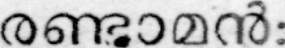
രണ്ടാമന്‍:
